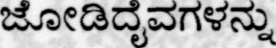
ಜೋಡಿದೈವಗಳನ್ನು
